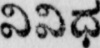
ವಿವಿಧ
